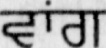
ਵਾਂਗ
